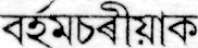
বর্হমচৰীয়াক
